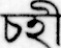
চহী
